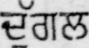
ਦੁੱਗਲ
